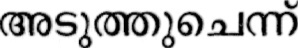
അടുത്തുചെന്ന്
